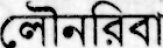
লৌনরিবা
